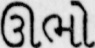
ઊભો
